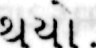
થયો.
